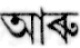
আৰু
